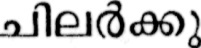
ചിലര്‍ക്കു
